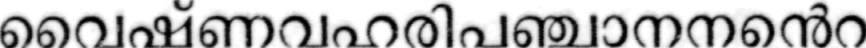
വൈഷ്ണവഹരിപഞ്ചാനനന്റെ
